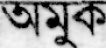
অমুক
